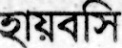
হায়সি
